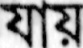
যায়
